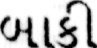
બાકી
